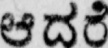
ಆದರೆ
